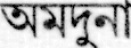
অমদুনা
